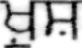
ਖ਼ੁਸ਼
